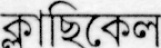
ক্লাছিকেল
